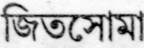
জিতসোমা
